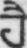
ਹੈ
